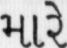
મારે
